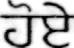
ਹੋਏ
